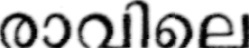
രാവിലെ
